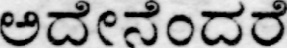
ಅದೇನೆಂದರೆ
